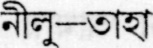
নীলু—তাহা
